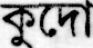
কুদো
